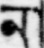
না
